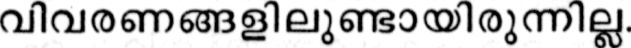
വിവരണങ്ങളിലുണ്ടായിരുന്നില്ല.
